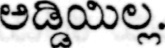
ಅಡ್ಡಿಯಿಲ್ಲ.
